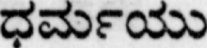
ಧರ್ಮಯು
